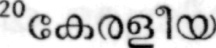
20കേരളീയ
